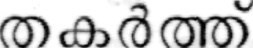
തകര്‍ത്ത്
